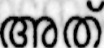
അത്
